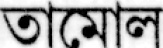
তামোল
